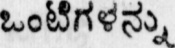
ಒಂಟೆಗಳನ್ನು
